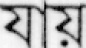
যায়
